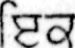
ਇਕ
